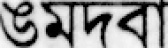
ঙমদবা
